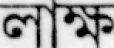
লাক্ষ
